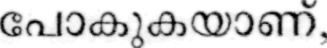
പോകുകയാണ്,
